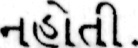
નહોતી.
